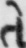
તે
